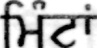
ਮਿੰਟਾਂ
